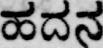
ಹದನ
